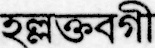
হল্লক্তবগী
